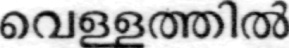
വെള്ളത്തില്‍
